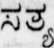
ಸತ್ಯ
